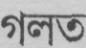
গলত
